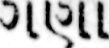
ગણા
